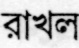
রাখল
